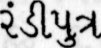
રંડીપુત્ર
